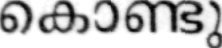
കൊണ്ടു
